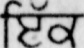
ਇੱਕ
